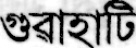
গুৱাহাটি
